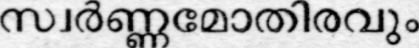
സ്വര്‍ണ്ണമോതിരവും
